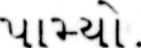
પામ્યો.
